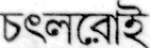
চৎলরোই
